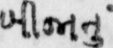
બીજાનું
